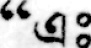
“এঃ
